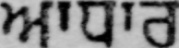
ਆਧਾਰ
